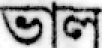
ভাল
